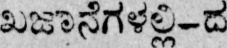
ಖಜಾನೆಗಳಲ್ಲಿ-ದ
